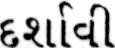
દર્શાવી
